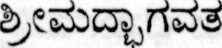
ಶ್ರೀಮದ್ಭಾಗವತ
